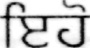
ਇਹੋ
